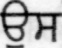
ਉਸ
